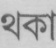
থকা
